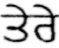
ਤੇਰੇ
